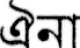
ঐনা
